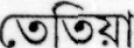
তেতিয়া
